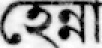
হেন্না
